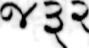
જરૂર
